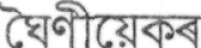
ঘৈণীয়েকৰ
